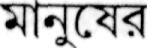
মানুষের
